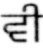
ਵੀ
